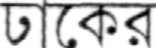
ঢাকের
